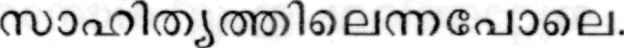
സാഹിത്യത്തിലെന്നപോലെ,
